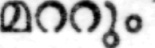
മററും
